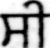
ਸੀ
